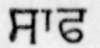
ਸਾਫ
